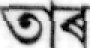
তাৰ
